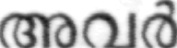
അവര്‍
